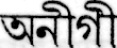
অনীগী
